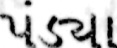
પંડ્યા
